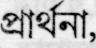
প্রার্থনা,
